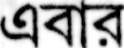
এবার
